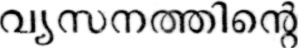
വ്യസനത്തിന്റെ
